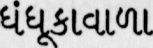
ધંધૂકાવાળા
